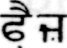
ਫ਼ੈਜ਼
